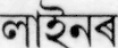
লাইনৰ
